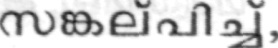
സങ്കല്പിച്ച്,
